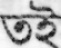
তই
